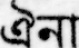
ঐনা
